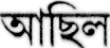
আছিল
